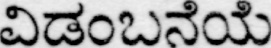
ವಿಡಂಬನೆಯೆ
